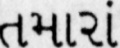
તમારાં
